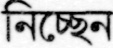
নিচ্ছেন
